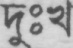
দুঃখ
